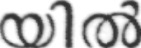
യില്‍
